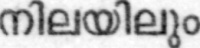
നിലയിലും
